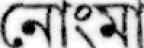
নোংমা
